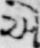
એ
